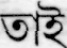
তাই
